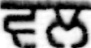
ਵਲ
